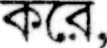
করে,
